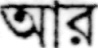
আর
